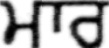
ਮਾਰ
